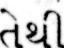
તેથી
